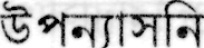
উপন্যাসনি
